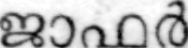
ജാഫര്‍
